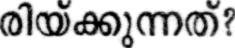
രിയ്ക്കുന്നത്?
